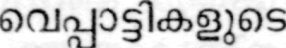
വെപ്പാട്ടികളുടെ
